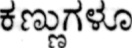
ಕಣ್ಣುಗಳೂ
